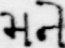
મને
